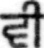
ਵੀ
